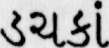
ડચકાં
